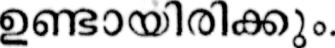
ഉണ്ടായിരിക്കും.
